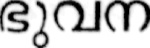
ഭുവന
